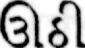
ઊઠી
